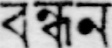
বন্ধন
